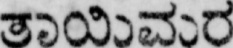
ತಾಯಿಮರ
